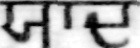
ਯਾਦ
